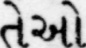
તેઓ
